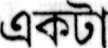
একটা
